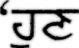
'ਹੁਣ
